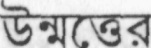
উন্মত্তের
